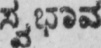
ಸ್ವಭಾವ
